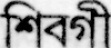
শিবগী
